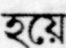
হয়ে
